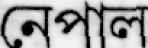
নেপাল
